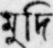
মুদি
